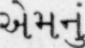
એમનું
